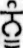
ਨੂੰ
